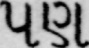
પણ
